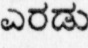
ಎರಡು
